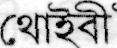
থোইবী
